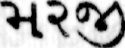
મરજી
